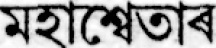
মহাশ্বেতাৰ
